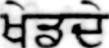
ਖੇਡਦੇ
